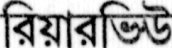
রিয়ারভিউ
